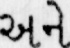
અને
